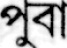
পুবা
